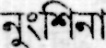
নুংশিনা
